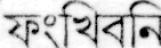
ফংখিবনি
